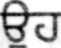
ਉਹ
